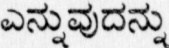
ಎನ್ನುವುದನ್ನು
